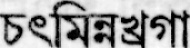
চৎমিন্নখ্রগা
